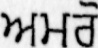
ਅਮਰੋ
